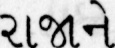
રાજાને
